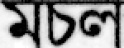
মচল
